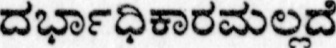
ದರ್ಭಾಧಿಕಾರಮಲ್ಲದೆ
